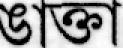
ঙাক্তা
